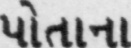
પોતાના
